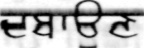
ਦਬਾਉਣ
